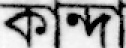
কান্দা
